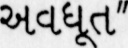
અવધૂત"
